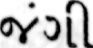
જંગી
